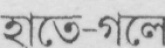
হাতে-গলে
